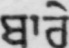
ਬਾਰੇ
